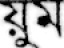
য়ুম
